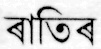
ৰাতিৰ
